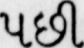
પછી
